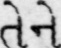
તેને
